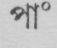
পা
